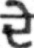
ਦੇ
